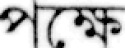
পক্ষে
